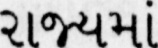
રાજ્યમાં
